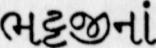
ભટ્ટજીનાં
